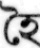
হৈ
